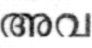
അവ
